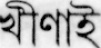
খীণাই
